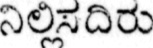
ನಿಲ್ಲಿಸದಿರು
